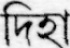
দিহা
